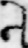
ને
